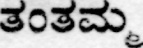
ತಂತಮ್ಮ
